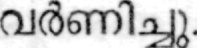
വര്‍ണിച്ചു.
